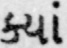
ક્યાં
